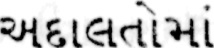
અદાલતોમાં
